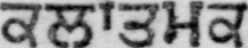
ਕਲਾਤਮਕ
